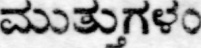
ಮುತ್ತುಗಳಂ
